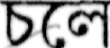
চলে
